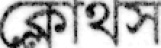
ক্লোথস
